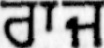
ਰਾਜ
